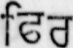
ਫਿਰ
